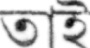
তাই
